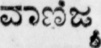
ವಾಣಿಜ್ಯ
